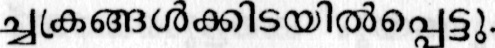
ച്ചക്രങ്ങള്‍ക്കിടയില്‍പ്പെട്ടു.
